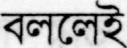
বললেই
